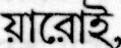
য়ারোই,
